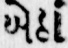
બેઠાં
